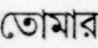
তোমার
